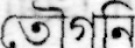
তৌগনি
